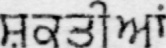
ਸ਼ਕਤੀਆਂ
